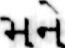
મને
